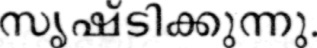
സൃഷ്ടിക്കുന്നു.
